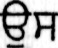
ਉਸ
